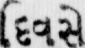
દિવસે
